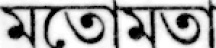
মতোমতা
